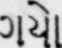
ગયો
